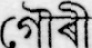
গৌৰী
